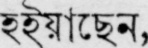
হইয়াছেন,
